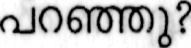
പറഞ്ഞു?
